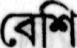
বেশি
